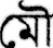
মৌ
